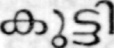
കുട്ടി
